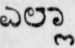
ಎಲ್ಲಾ
